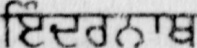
ਇੰਦਰਨਾਥ
